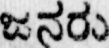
ಜನರು
